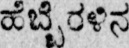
ಹೆಬ್ಬೆರಳಿನ
